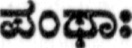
ಪಂಥಾಃ
